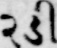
રડી
